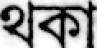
থকা
